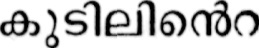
കുടിലിന്റെ
